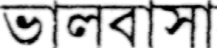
ভালবাসা
